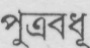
পুত্রবধূ
